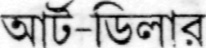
আর্ট-ডিলার
